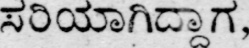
ಸರಿಯಾಗಿದ್ದಾಗ,
